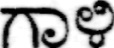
ಗಾಳಿ
